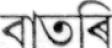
বাতৰি
